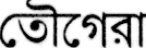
তৌগেরা
